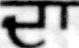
ਦਾ
